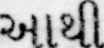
આથી
